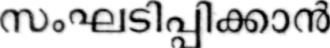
സംഘടിപ്പിക്കാന്‍
